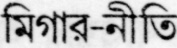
মিগার-নীতি
